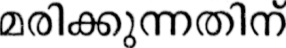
മരിക്കുന്നതിന്
